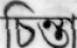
চিন্তা
